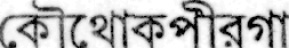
কৌথোকপীরগা
